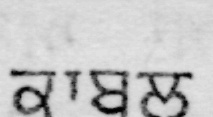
ਕਾਬਲ
